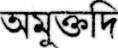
অমুক্তদি
